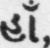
હાઁ,
